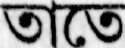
তাতে
